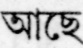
আছে
